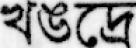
খঙদ্রে
